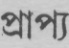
প্ৰাপ্য
